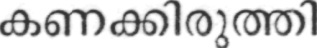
കണക്കിരുത്തി
